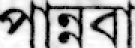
পান্নবা
